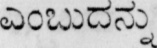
ಎಂಬುದನ್ನು
